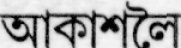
আকাশলৈ
